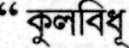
“কুলবিধূ
